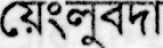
য়েংলুবদা
